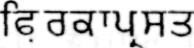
ਫ਼ਿਰਕਾਪ੍ਰਸਤ
